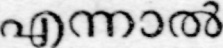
എന്നാല്‍
